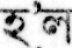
হ'ল
